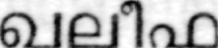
ഖലീഫ
